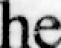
he
